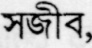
সজীব,
